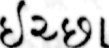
ઈચ્છા
